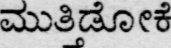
ಮುತ್ತಿಡೋಕೆ
